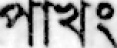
পাখং
